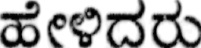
ಹೇಳಿದರು
